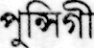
পুন্সিগী
